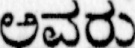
ಅವರು
